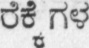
ರೆಕ್ಕೆಗಳ
